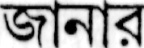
জানার
